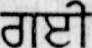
ਗਈ
